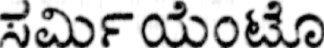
ಸರ್ಮಿಯೆಂಟೊ
